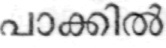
പാക്കില്‍
